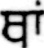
ਥਾਂ
